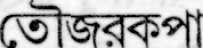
তৌজরকপা
